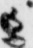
હું
